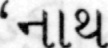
'નાથ
